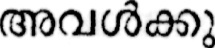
അവള്‍ക്കു
